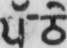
ਪੱਠੇ
